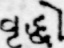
વૃદ્ધો
